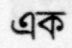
এক
